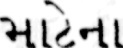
માટેના
